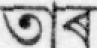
তাৰ
